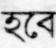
হবে
